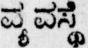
ವ್ಯವಸ್ಥೆ
